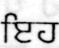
ਇਹ
